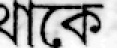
থাকে
